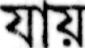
যায়
